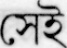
সেই
